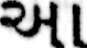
આ
